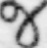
જ
